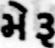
મેરૂ
